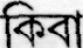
কিবা
